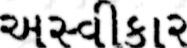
અસ્વીકાર
